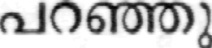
പറഞ്ഞു
